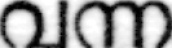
വന്ന
